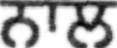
ਨਾਲ
